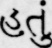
હતું
